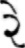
રે
